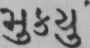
મુક્યું
